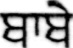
ਬਾਬੇ
